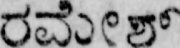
ರಮೇಶ್
